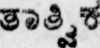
ತಾತ್ವಿಕ
